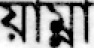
য়াম্না
